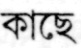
কাছে
